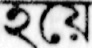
হয়ে
